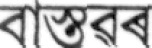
বাস্তৱৰ
